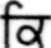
ਕਿ
